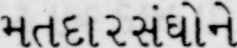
મતદારસંઘોને
